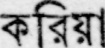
করিয়া
